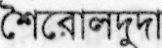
শৈরোলদুদা
